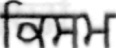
ਕਿਸਮ
